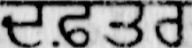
ਦਫ਼ਤਰ
